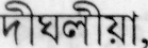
দীঘলীয়া,
